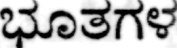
ಭೂತಗಳ
